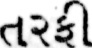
તરફી
